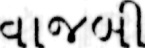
વાજબી
